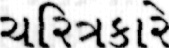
ચરિત્રકારે
